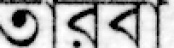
তারবা
